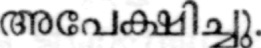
അപേക്ഷിച്ചു.
